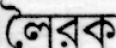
লৈরক
